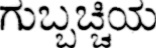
ಗುಬ್ಬಚ್ಚಿಯ
